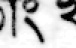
তাং
